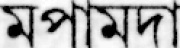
মপামদা
